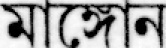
মাঙ্গোন
